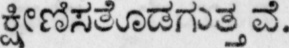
ಕ್ಷೀಣಿಸತೊಡಗುತ್ತವೆ.
